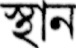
স্থান
